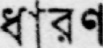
ধারণ
